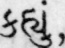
કહ્યું,
